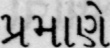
પ્રમાણે
